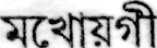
মখোয়গী
